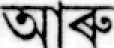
আৰু
